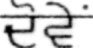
ਦੋਵੇਂ
